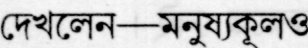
দেখলেন–মনুষ্যকূলও
